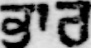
ਭਾਰ
